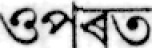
ওপৰত
